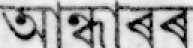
আন্ধাৰৰ
